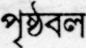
পৃষ্ঠবল
